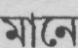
মানে
